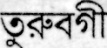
তুরুবগী
